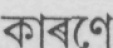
কাৰণে
